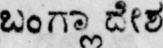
ಬಂಗ್ಲಾದೇಶ
